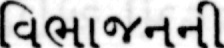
વિભાજનની
